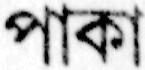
পাকা
